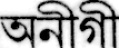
অনীগী
